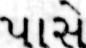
પાસે
